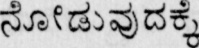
ನೋಡುವುದಕ್ಕೆ
